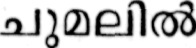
ചുമലില്‍
